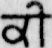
ਕੀ
